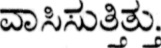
ವಾಸಿಸುತ್ತಿತ್ತು.
